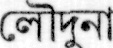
লৌদুনা
